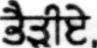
ਭੈੜੀਏ,
